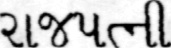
રાજપત્ની
